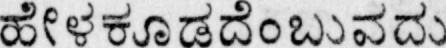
ಹೇಳಕೂಡದೆಂಬುವದು
